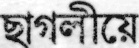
ছাগলীয়ে
